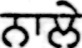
ਨਾਲੇ
